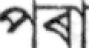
পৰা
